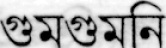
গুমগুমনি
